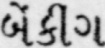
બેકીંગ
